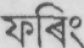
ফৰিং
